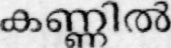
കണ്ണില്‍
